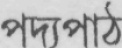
পদ্যপাঠ
